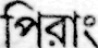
পিরাং
